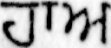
ਹਾਅ
